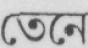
তেনে
